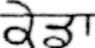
ਕੇਡਾ
